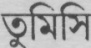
তুমিসি
